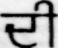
ਦੀ
